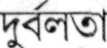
দুর্বলতা
